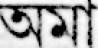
অমা
